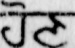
ਹੋਣ
